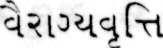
વૈરાગ્યવૃત્તિ
